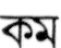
কম
